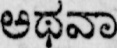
ಅಥವಾ
